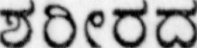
ಶರೀರದ
